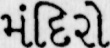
મંદિરો
